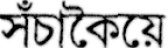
সঁচাকৈয়ে
